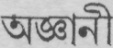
অজ্ঞানী
